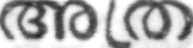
അത്ര
